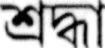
শ্রদ্ধা
